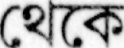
থেকে
